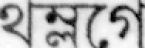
থম্লগে
